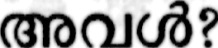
അവള്‍?
